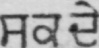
ਸਕਦੇ
